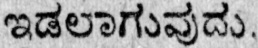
ಇಡಲಾಗುವುದು.
